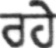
ਰਹੇ
